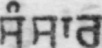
ਸੰਸਾਰ
